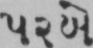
પરબે
